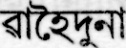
ৱাহৈদুনা
